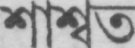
শাশ্বত
